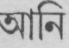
আনি
